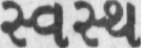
સ્વસ્થ
